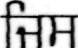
ਜਿਸ
